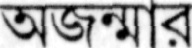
অজন্মার
